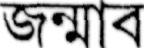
জন্মাব
